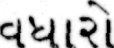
વધારો
